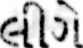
લીગે
